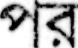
পর
